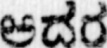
ಅದರ
